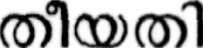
തീയതി
